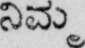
ನಿಮ್ಮ
